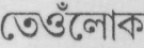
তেওঁলোক
